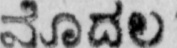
ಮೊದಲ
